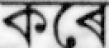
কৰে
